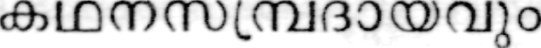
കഥനസമ്പ്രദായവും
